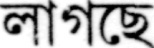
লাগছে
